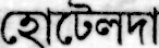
হোটেলদা
